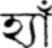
হ্যাঁ
